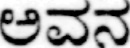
ಅವನ
